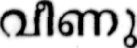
വീണു
